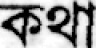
কথা
